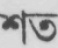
শত
